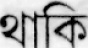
থাকি
